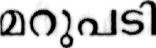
മറുപടി
